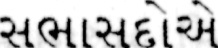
સભાસદોએ
